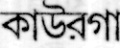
কাউরগা
